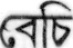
বেচি
